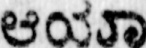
ಆಯಾ
